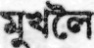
মুখলৈ
